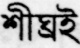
শীঘ্রই
